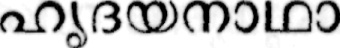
ഹൃദയനാഥാ
